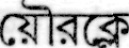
য়ৌরক্লে
